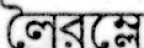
লৈরম্লে
